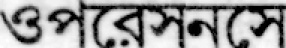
ওপরেসনসে
